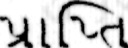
પ્રાપ્તિ
